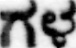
ಗಳ
